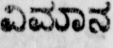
ವಿಮಾನ
